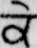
ਕੇ
